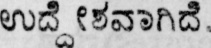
ಉದ್ದೇಶವಾಗಿದೆ.
